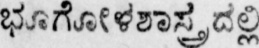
ಭೂಗೋಳಶಾಸ್ತ್ರದಲ್ಲಿ
